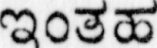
ಇಂತಹ
